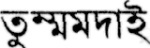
তুম্মমদাই
